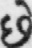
છે
